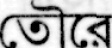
তৌরে
